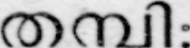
തമ്പി:
